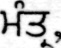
ਮੰਤ੍ਰ,
